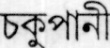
চকুপানী
